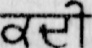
ਕਦੀ
